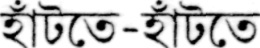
হাঁটতে-হাঁটতে
